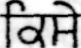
ਕਿਸੇ
